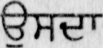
ਉਸਦਾ
